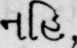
નહિ,
